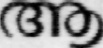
ആ
